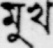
মুখ
